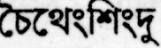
চৈথেংশিংদু
